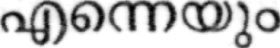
എന്നെയും
